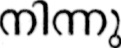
നിന്നു
